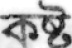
কষ্ট
